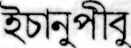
ইচানুপীবু
